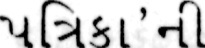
પત્રિકા'ની
